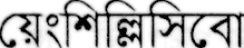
য়েংশিল্লিবসিবো
